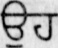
ਉਹ
